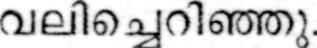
വലിച്ചെറിഞ്ഞു.
